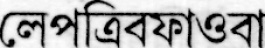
লেপত্রিবফাওবা
